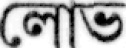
লোভ
